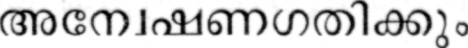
അന്വേഷണഗതിക്കും
